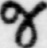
જ
